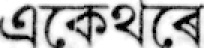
একেথৰে
